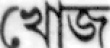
খোজ
